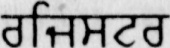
ਰਜਿਸਟਰ
